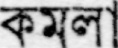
কমলা
